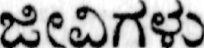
ಜೀವಿಗಳು
